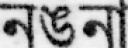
নঙনা
